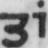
ਤਾਂ
